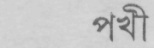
পখী
